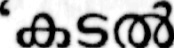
‘കടല്‍
